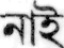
নাই
